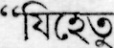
"যিহেতু
